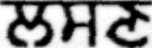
ਲਸਣ
